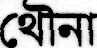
থৌনা
